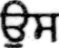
ਉਸ
